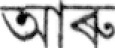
আৰু
